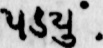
પડ્યું.
